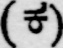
(ಕ)
